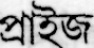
প্ৰাইজ
